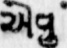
એવું
